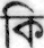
কি
